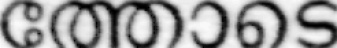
ത്തോടെ
